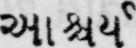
આશ્ર્ચર્ય
